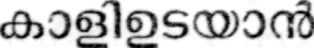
കാളിഉടയാന്‍
